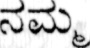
ನಮ್ಮ
